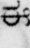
ಈ
